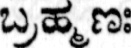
ಬ್ರಹ್ಮಣಃ
